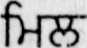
ਮਿਲ
